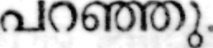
പറഞ്ഞു.
